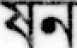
ষন
